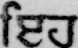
ਇਹ
